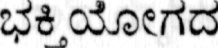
ಭಕ್ತಿಯೋಗದ
